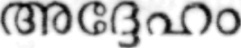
അദ്ദേഹം
